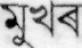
মুখৰ
